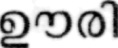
ഊരി
